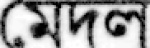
মেদল
